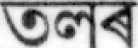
তলৰ
